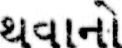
થવાનો
